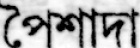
পৈশাদা
